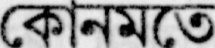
কোনমতে
